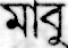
মাবু
